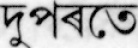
দুপৰতে
